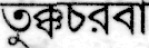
তুক্কচরবা
